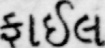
ફાઈલ
